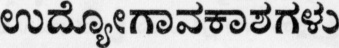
ಉದ್ಯೋಗಾವಕಾಶಗಳು
